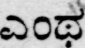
ಎಂಥ
